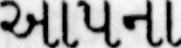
આપના
